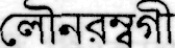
লৌনরম্বগী
